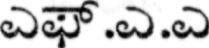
ಎಫ್.ಎ.ಎ.
